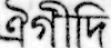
ঐগীদি
